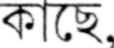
কাছে,
